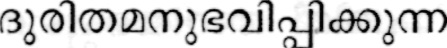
ദുരിതമനുഭവിപ്പിക്കുന്ന
